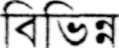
বিভিন্ন
